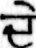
ਦੇ
